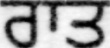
ਰਾਤ
